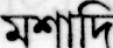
মশাদি
